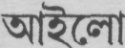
আইলো
